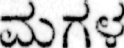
ಮಗಳ
